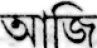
আজি
